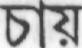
চায়
